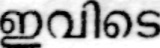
ഇവിടെ
